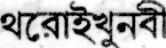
থরোইখুনবী
